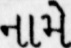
નામે
